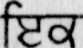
ਇਕ
